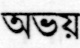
অভয়
